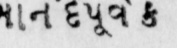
આનંદપૂર્વક
